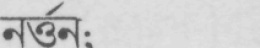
নৰ্ত্তন;
